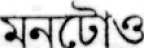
মনটোও
